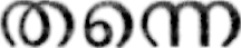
തന്നെ
